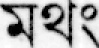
মথং
